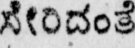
ಸೇರಿದಂತೆ
